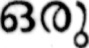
ഒരു
